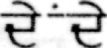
ਦੇਂਦੇ
